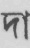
দা
